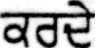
ਕਰਦੇ
